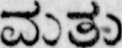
ಮತು
